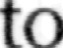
to
